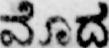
ಮೊದ
